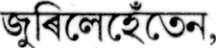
জুৰিলেহেঁতেন,
